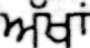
ਅੱਖਾਂ
